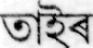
তাইৰ
